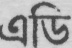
এড়ি
